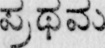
ಪ್ರಥಮ
